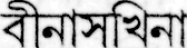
বীনাসখিনা
